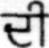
ਦੀ
